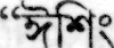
“ঈশিং
